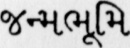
જન્મભૂમિ
